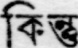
কিন্তু
